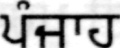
ਪੰਜਾਹ
